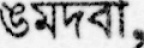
ঙমদবা,
